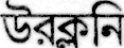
উরক্লনি
